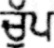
ਚੁੱਪ
